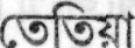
তেতিয়া
